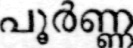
പൂര്‍ണ്ണ
